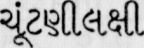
ચૂંટણીલક્ષી
